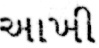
આખી
